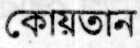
কোয়তান
